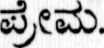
ಪ್ರೇಮ.
